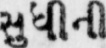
સુધીની
